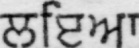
ਲਇਆ
